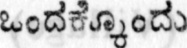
ಒಂದಕ್ಕೊಂದು
